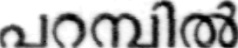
പറമ്പില്‍
